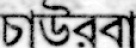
চাউরবা
